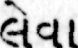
લેવા
